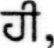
ਹੀ,
